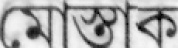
মোস্তাক
